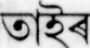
তাইৰ
